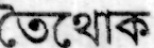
তৈথোক
